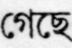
গেছে
